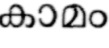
കാമം
